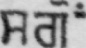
ਸਗੋਂ
